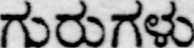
ಗುರುಗಳು
